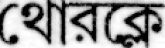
থোরক্লে
